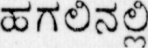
ಹಗಲಿನಲ್ಲಿ
